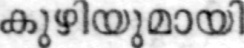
കുഴിയുമായി
